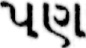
પણ
